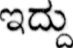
ಇದ್ದು
